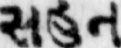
સહન
